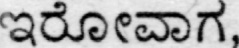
ಇರೋವಾಗ,
